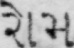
રોમ
